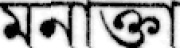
মনাক্তা
